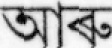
আৰু
